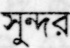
সুন্দর
